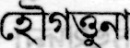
হৌগত্তুনা
